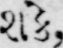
શકે,
